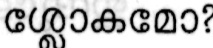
ശ്ലോകമോ?
